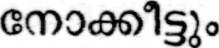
നോക്കീട്ടും
